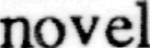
novel
